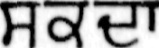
ਸਕਦਾ
